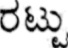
ರಟ್ಟು
